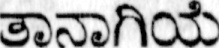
ತಾನಾಗಿಯೆ
